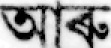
আৰু
